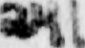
આ
